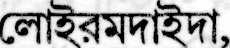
লোইরমদাইদা,
